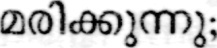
മരിക്കുന്നു;
